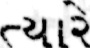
ત્યારે
